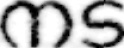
നട
